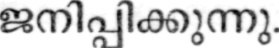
ജനിപ്പിക്കുന്നു.
